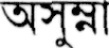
অসুম্না
